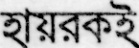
হায়রকই
